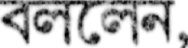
বললেন,
